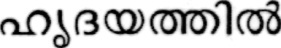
ഹൃദയത്തില്‍
